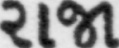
રાજા
